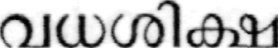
വധശിക്ഷ
